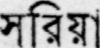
সরিয়া
